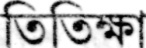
তিতিক্ষা
